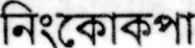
নিংকোকপা
